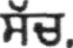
ਸੱਚ,
